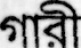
গারী
